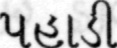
પહાડી
